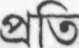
প্রতি
